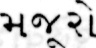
મજૂરો
